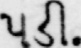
પડી.
